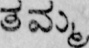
ತಮ್ಮ
